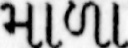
માળા
